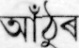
আঁঠুৰ
